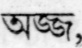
অজ্জ,
